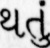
થતું
